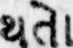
થતો
